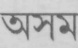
অসম
